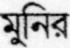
মুনির
